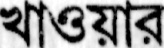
খাওয়ার
